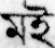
মই
